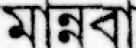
মান্নবা
